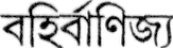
বহির্বাণিজ্য
